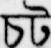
চট
